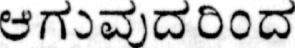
ಆಗುವುದರಿಂದ
